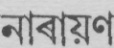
নাৰায়ণ
